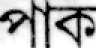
পাক
